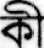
কী
